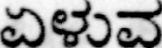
ಏಳುವ
